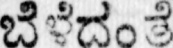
ಬೆಳೆದಂತೆ
